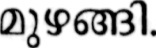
മുഴങ്ങി.
